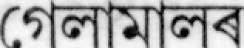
গেলামালৰ
